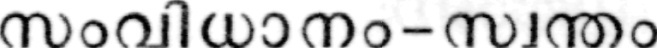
സംവിധാനം-സ്വന്തം
